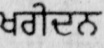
ਖਰੀਦਨ
